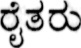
ರೈತರು
